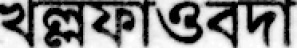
খল্লফাওবদা
